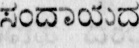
ಸಂದಾಯದ
